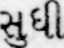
સુધી
